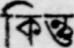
কিন্তু
